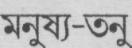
মনুষ্য-তনু
